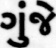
ગુંજે
